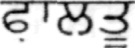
ਫ਼ਾਲਤੂ
